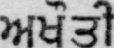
ਅਖੌਤੀ
